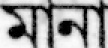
মানা
